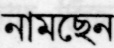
নামছেন
